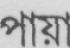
পায়া
